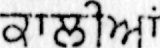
ਕਾਲੀਆਂ
